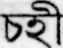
চহী
